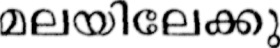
മലയിലേക്കു
